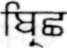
ਬ੍ਰਿਛ
